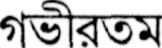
গভীরতম
